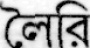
লৈরি
